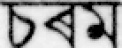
চৰম
